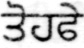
ਤੋਹਫੇ
